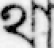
থা
